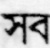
সব
